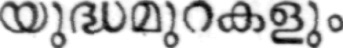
യുദ്ധമുറകളും
